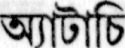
অ্যাটাচি
